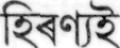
হিৰণ্যই
